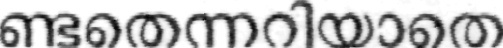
ണ്ടതെന്നറിയാതെ
